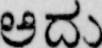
ಅದು
